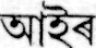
আইৰ
